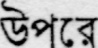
উপরে
